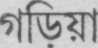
গড়িয়া
